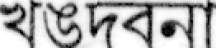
খঙদবনা
